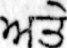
ਅਤੇ
